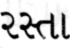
રસ્તા
